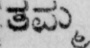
ತಮ್ಮ
